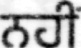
ਨਹੀਂ
